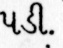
પડી.
